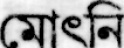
মোৎনি
